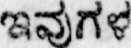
ಇವುಗಳ
